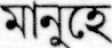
মানুহে
